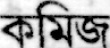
কমিজ
